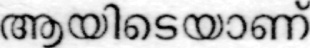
ആയിടെയാണ്
